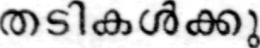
തടികള്‍ക്കു
